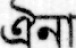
ঐনা
